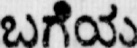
ಬಗೆಯ
